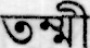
তম্মী
